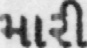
મારી
